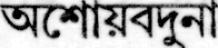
অশোয়বদুনা
